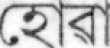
হোৱা
